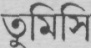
তুমিসি
